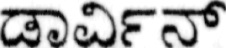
ಡಾರ್ವಿನ್
